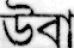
উবা
